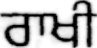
ਰਾਖੀ
